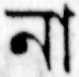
না
